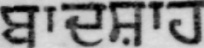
ਬਾਦਸ਼ਾਹ
